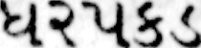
ધરપકડ
